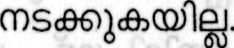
നടക്കുകയില്ല.
